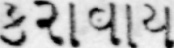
કરાવાય
